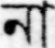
না
